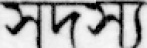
সদস্য
